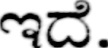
ಇದೆ.
